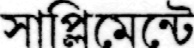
সাপ্লিমেন্টে
